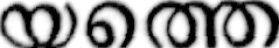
യത്തെ
